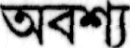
অবশ্য
